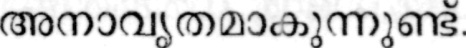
അനാവൃതമാകുന്നുണ്ട്.
